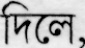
দিলে,
